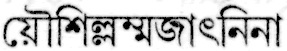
য়ৌশিল্লম্মজাৎনিনা
